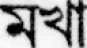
মখা
